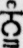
ਨੂੰ
